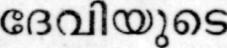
ദേവിയുടെ
